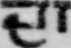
ਦਾ
